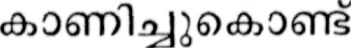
കാണിച്ചുകൊണ്ട്
